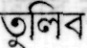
তুলিব
